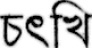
চৎখি
